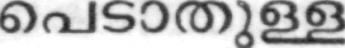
പെടാതുള്ള
